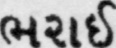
ભરાઈ
